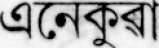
এনেকুৱা
